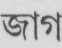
জাগ
